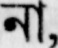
না,
